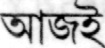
আজই
